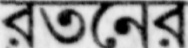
রতনের
